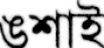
ঙশাই
